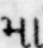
મા
